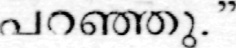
പറഞ്ഞു.''
